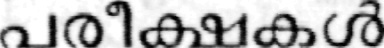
പരീക്ഷകള്‍
